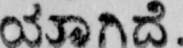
ಯಾಗಿದೆ.
